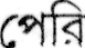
পেরি
